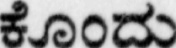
ಕೊಂದು
